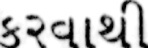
કરવાથી
